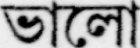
ভালো
